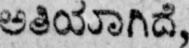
ಅತಿಯಾಗಿದೆ,
